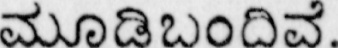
ಮೂಡಿಬಂದಿವೆ.
